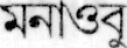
মনাওবু
